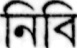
নিবি
